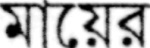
মায়ের
